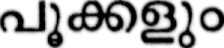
പൂക്കളും
